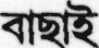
বাছাই
